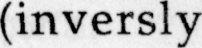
(inversly
